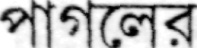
পাগলের
